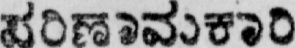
ಪರಿಣಾಮಕಾರಿ
